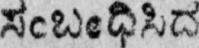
ಸಂಬಂಧಿಸಿದ
